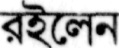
রইলেন
